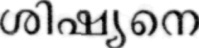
ശിഷ്യനെ
